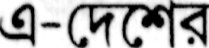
এ-দেশের
